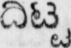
ದಿಟ್ಟ
